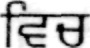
ਵਿਚ
